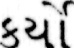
કર્યો
